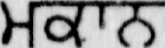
ਮਕਾਨ
